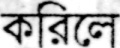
করিলে
